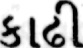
કાઢી
